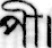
পী।
